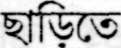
ছাড়িতে
